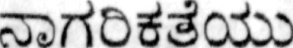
ನಾಗರಿಕತೆಯು
